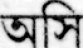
অসি
